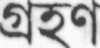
গ্রহণ
